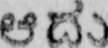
ಆದು
